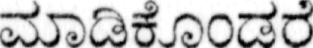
ಮಾಡಿಕೊಂಡರೆ
